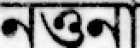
নত্তনা
